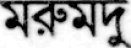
মরুমদু
